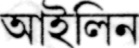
আইলিন
